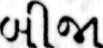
બીજા
